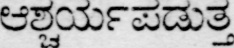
ಆಶ್ಚರ್ಯಪಡುತ್ತ
